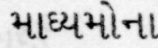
માધ્યમોના
